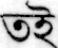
তই
